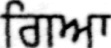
ਗਿਆ
